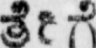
ತೆರಿಗೆ
